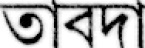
তাবদা
